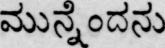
ಮುನ್ನೆಂದನು
